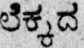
ಲೆಕ್ಕದ
